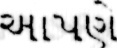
આપણે
